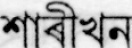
শাৰীখন
